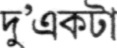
দু’একটা
